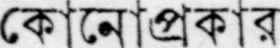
কোনোপ্রকার
